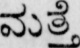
ಮತ್ತೆ
